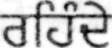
ਰਹਿੰਦੇ
